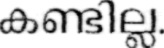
കണ്ടില്ല.
